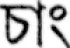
চাং
